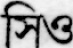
সিও
